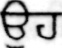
ਉਹ
